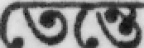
তেন্তে
